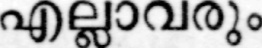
എല്ലാവരും
